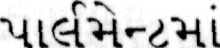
પાર્લમેન્ટમાં
